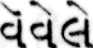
વૅવેલે
